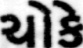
ચોકે
